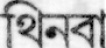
থিনবা
